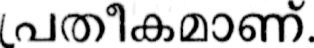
പ്രതീകമാണ്.
